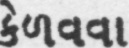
કેળવવા
